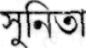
সুনিতা
